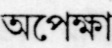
অপেক্ষা
